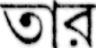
তার
